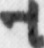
ન
